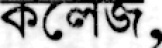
কলেজ,
